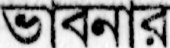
ভাবনার
